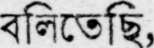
বলিতেছি,
